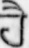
ਹੈ
